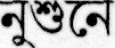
নুশুনে
